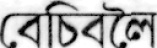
বেচিবলৈ
